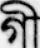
গী
